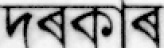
দৰকাৰ
